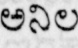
ಅನಿಲ
